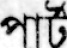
পার্ট
